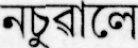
নচুৱালে
